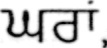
ਘਰਾਂ,
